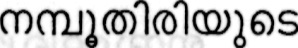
നമ്പൂതിരിയുടെ
